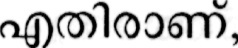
എതിരാണ്,
